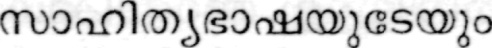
സാഹിത്യഭാഷയുടേയും
